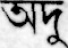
অদু
